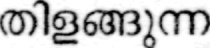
തിളങ്ങുന്ന
